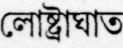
লোষ্ট্রাঘাত
